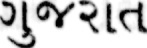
ગુજરાત
